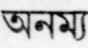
অনম্য
